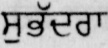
ਸੁਭੱਦਰਾ
